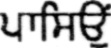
ਪਾਸਿਉਂ
